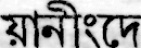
য়ানীংদে
